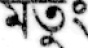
মতুং
